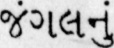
જંગલનું
